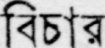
বিচার
